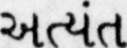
અત્યંત
